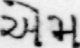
એમ
